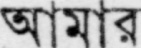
আমার
